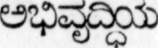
ಅಭಿವೃದ್ಧಿಯ
